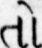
તો
